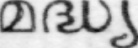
മദ്ധ്യ
